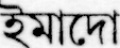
ইমাদো
